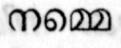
നമ്മെ
